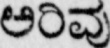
ಅರಿವು
